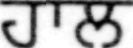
ਹਾਲ
